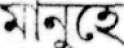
মানুহে
